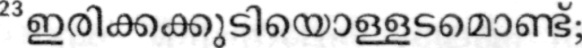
23ഇരിക്കക്കുടിയൊള്ളടമൊണ്ട്;
